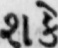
શકે
